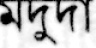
মদুদা
